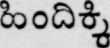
ಹಿಂದಿಕ್ಕಿ
